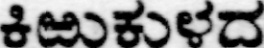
ಕಿಱುಕುಳದ
